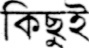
কিছুই
